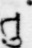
તું
